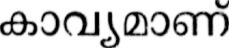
കാവ്യമാണ്
